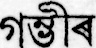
গম্ভীৰ
